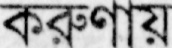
করুণায়
